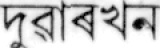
দুৱাৰখন
